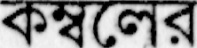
কম্বলের
